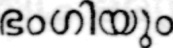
ഭംഗിയും
